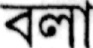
বলা
